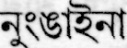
নুংঙাইনা
